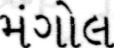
મંગોલ
